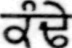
ਕੰਢੇ
